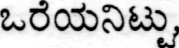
ಒರೆಯನಿಟ್ಟು
